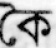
কৈ
